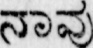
ನಾವು
